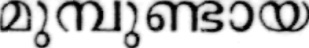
മുമ്പുണ്ടായ
